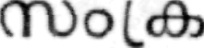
സംക്ര
